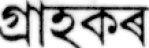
গ্রাহকৰ
